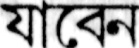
যাবেন
